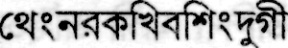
থেংনরকখিবশিংদুগী
